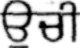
ਉਚੀ
